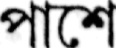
পাশে
